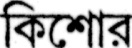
কিশোর
